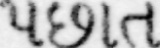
પછાત
